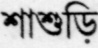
শাশুড়ি
